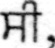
ਸੀ,
